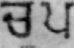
ਚੁਪ
